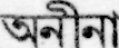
অনীনা
